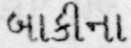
બાકીના
